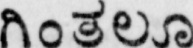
ಗಿಂತಲೂ
